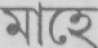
মাহে
